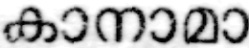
കാനാമാ
